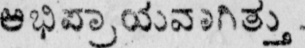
ಅಭಿಪ್ರಾಯವಾಗಿತ್ತು.
